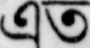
এত
